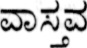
ವಾಸ್ತವ
